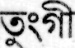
তুংগী
